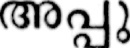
അപ്പു
